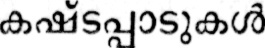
കഷ്ടപ്പാടുകള്‍
